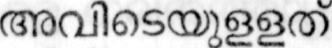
അവിടെയുള്ളത്
